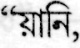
“য়ানি,
